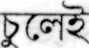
চুলেই
